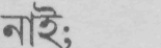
নাই;
